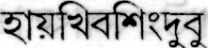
হায়খিবশিংদুবু
